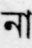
না
